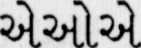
એઓએ
